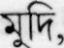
মুদি,
